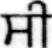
ਸੀ
